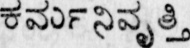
ಕರ್ಮನಿವೃತ್ತಿ
